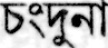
চংদুনা
